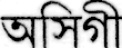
অসিগী
